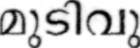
മുടിവു
